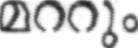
മററും
